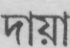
দায়া
